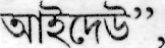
আইদেউ",
